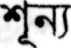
শূন্য
